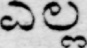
ಎಲ್ಲ
